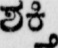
ಶಕ್ತಿ
